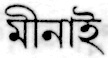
মীনাই
